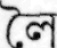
লৈ
